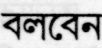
বলবেন
